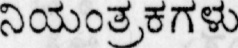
ನಿಯಂತ್ರಕಗಳು
